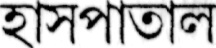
হাসপাতাল
